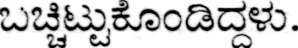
ಬಚ್ಚಿಟ್ಟುಕೊಂಡಿದ್ದಳು.
